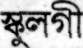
স্কুলগী
